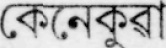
কেনেকুৱা
